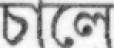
চালে
